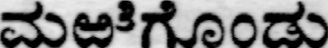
ಮಱೆಗೊಂಡು
